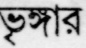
ভৃঙ্গার
